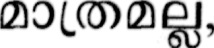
മാത്രമല്ല,
